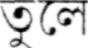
তুলে
